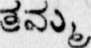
ತಮ್ಮ
